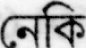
নেকি
